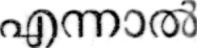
എന്നാല്‍
